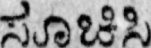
ಸೂಚಿಸಿ
